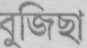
বুজিছা
